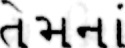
તેમનાં
